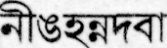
নীংঙহন্নদবা
